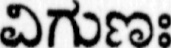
ವಿಗುಣಃ
